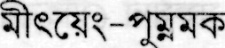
মীৎয়েং-পুম্নমক
